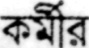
কর্মীর
